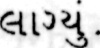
લાગ્યું.
